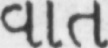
વાત
